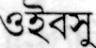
ওইবসু
